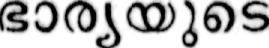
ഭാര്യയുടെ
